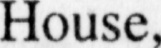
House,
